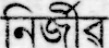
নিৰ্জীৱ
